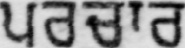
ਪਰਚਾਰ
